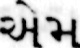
એમ
